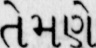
તેમણે
